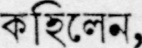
কহিলেন,
